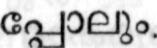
പ്പോലും.
